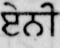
ਏਨੀ
